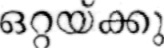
ഒറ്റയ്ക്കു
